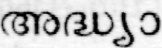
അദ്ധ്യാ
